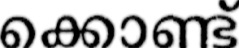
ക്കൊണ്ട്
